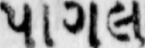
પાગલ
